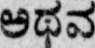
ಅಥವ
